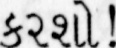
કરશો!
